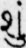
શું
